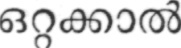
ഒറ്റക്കാല്‍
